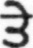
ਤੇ
